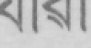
যোৱা
